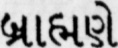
બ્રાહ્મણે
